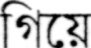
গিয়ে
